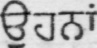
ਉਹਨਾਂ
